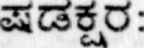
ಷಡಕ್ಷರ:
